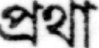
প্রথা
